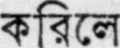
করিলে
